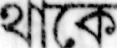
থাকে
